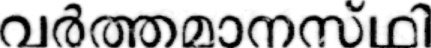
വര്‍ത്തമാനസ്ഥി
